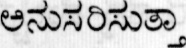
ಅನುಸರಿಸುತ್ತಾ
